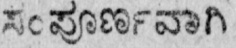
ಸಂಪೂರ್ಣವಾಗಿ
